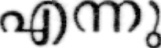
എന്നു
